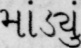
માંડ્યું
